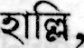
হাল্লি,
